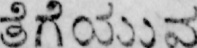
ತೆಗೆಯುವ
